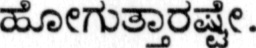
ಹೋಗುತ್ತಾರಷ್ಟೇ.
